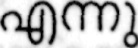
എന്നു
